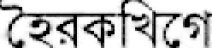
হৈরকখিগে
